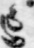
હું
